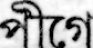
পীগে
